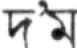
দ'ম
